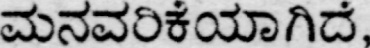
ಮನವರಿಕೆಯಾಗಿದೆ,
